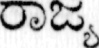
ರಾಜ್ಯ
